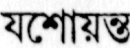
যশোয়ন্ত
